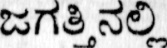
ಜಗತ್ತಿನಲ್ಲಿ
